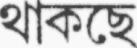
থাকছে
